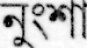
নুংশা
